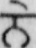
ਨੇ
